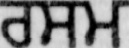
ਰਸਮ
